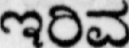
ಇರಿವ
